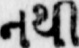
નથી
